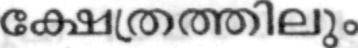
ക്ഷേത്രത്തിലും
